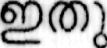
ഇതു
